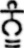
ਨੂੰ
